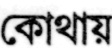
কোথায়
